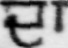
ਦਾ
